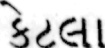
કેટલા
